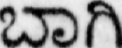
ಬಾಗಿ
